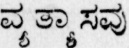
ವ್ಯತ್ಯಾಸವು
